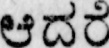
ಆದರೆ
